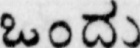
ಒಂದು
